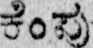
ಕೆಂಪು
